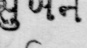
સુખને
